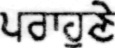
ਪਰਾਹੁਣੇ
